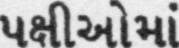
પક્ષીઓમાં
